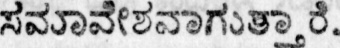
ಸಮಾವೇಶವಾಗುತ್ತಾರೆ.
